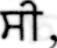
ਸੀ,
